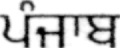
ਪੰਜਾਬ
